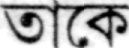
তাকে
